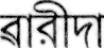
ৱারীদা
